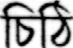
চিঠি
